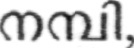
നമ്പി,
